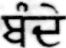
ਬੰਦੇ
